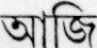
আজি
